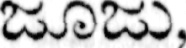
ಜೂಜು,
